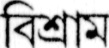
বিশ্রাম
